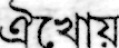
ঐখোয়
